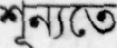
শূন্যতে
